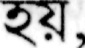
হয়,
